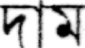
দাম
